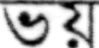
ভয়
